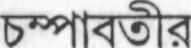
চম্পাবতীর
